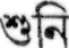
শুনি
